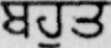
ਬਹੁਤ
